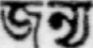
জন্য
